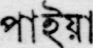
পাইয়া
